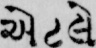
એટલે
